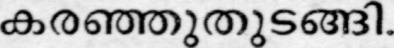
കരഞ്ഞുതുടങ്ങി.
